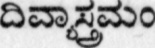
ದಿವ್ಯಾಸ್ತ್ರಮಂ
